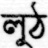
লুঠ
